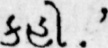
કહો.'
